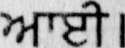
ਆਈ।
